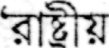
‘রাষ্ট্রীয়
